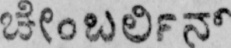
ಚೇಂಬರ್ಲಿನ್
